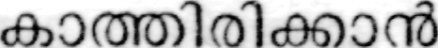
കാത്തിരിക്കാന്‍
